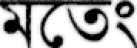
মতেং
